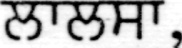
ਲਾਲਸਾ,
